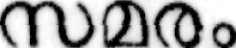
സമരം
